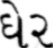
ધેર
